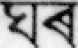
ঘৰ
